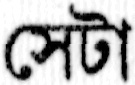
সেটা
